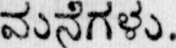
ಮನೆಗಳು,
